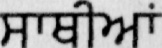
ਸਾਥੀਆਂ
